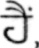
ਹੈਂ,
